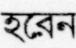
হবেন
